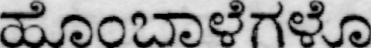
ಹೊಂಬಾಳೆಗಳೊ
